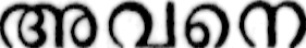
അവനെ
